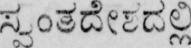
ಸ್ವಂತದೇಶದಲ್ಲಿ
